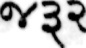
જરૂર
